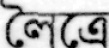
লৈত্রে
